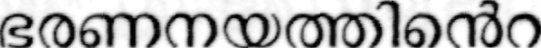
ഭരണനയത്തിന്റെ
